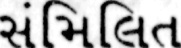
સંમિલિત
